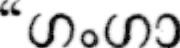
"ഗംഗാ
